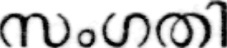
സംഗതി
